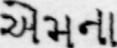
એમના
